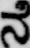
ನೆ
